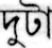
দুটা
